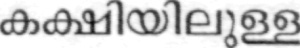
കക്ഷിയിലുള്ള
